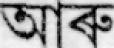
আৰু
